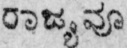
ರಾಜ್ಯವೂ
